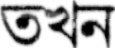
তখন
